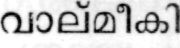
വാല്മീകി
